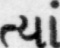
ત્યાં
